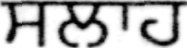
ਸਲਾਹ
